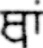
ਥਾਂ
